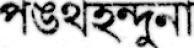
পঙথহন্দুনা
